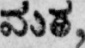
ಮತ,
